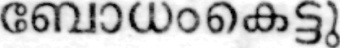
ബോധംകെട്ടു
